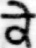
ਕੇ
